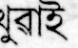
খুৱাই
